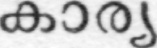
കാര്യ
